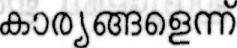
കാര്യങ്ങളെന്ന്
